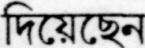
দিয়েছেন
